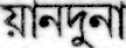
য়ানদুনা
